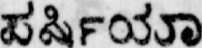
ಪರ್ಷಿಯಾ
